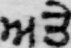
ਅਤੇ
